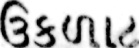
ઉકળાટ
